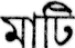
মাটি
